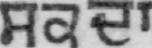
ਸਕਦਾ
